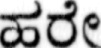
ಹರೇ
